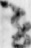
કે
